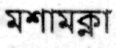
মশামক্না
